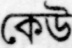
কেউ
